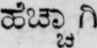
ಹೆಚ್ಚಾಗಿ
